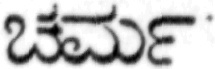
ಚರ್ಮ
